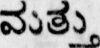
ಮತ್ತು
